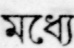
মধ্যে
